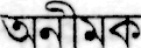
অনীমক
